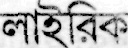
লাইরিক
